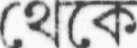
থেকে
